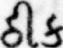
ઠીક
